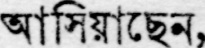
আসিয়াছেন,
